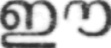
ഈ
